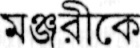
মঞ্জরীকে
